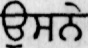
ਉਸਨੇ
